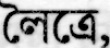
লৈত্রে,
